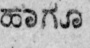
ಹಾಗೂ
